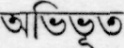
অভিভূত
